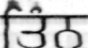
ਤਿੰਨ
